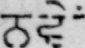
ਨਵੇਂ
